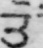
ਤੋਂ
